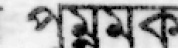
অরায়বা
